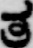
ತ
